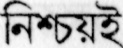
নিশ্চয়ই
